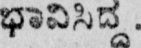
ಭಾವಿಸಿದ್ದ.
